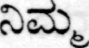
ನಿಮ್ಮ
